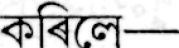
কৰিলে-
